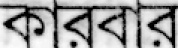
কারবার
